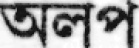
অলপ
